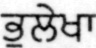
ਭੁਲੇਖਾ
